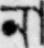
না
